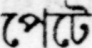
পেটে
